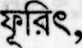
ফূরিৎ,
